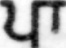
ਪਾ
